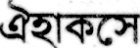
ঐহাকসে
